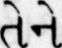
તેને
